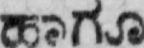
ಹಾಗೂ
